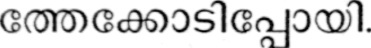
ത്തേക്കോടിപ്പോയി.
